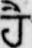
ਹੈ
